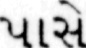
પાસે
